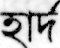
হার্দ
